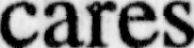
Cares
